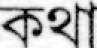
কথা
